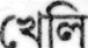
খেলি
